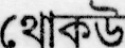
থোকউ
